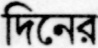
দিনের
